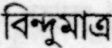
বিন্দুমাত্র
